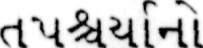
તપશ્ચર્યાનો
